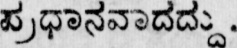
ಪ್ರಧಾನವಾದದ್ದು.
